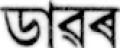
ডাৱৰ
